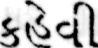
કહેવી
